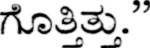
ಗೊತ್ತಿತ್ತು."
